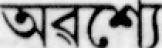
অৱশ্যে
